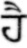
ਹੈ
